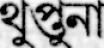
থুপ্তুনা
